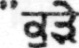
''ਕੁੜੇ
